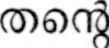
തന്റെ
